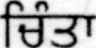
ਚਿੰਤਾ
